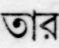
তার
